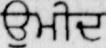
ਉਮੀਦ
